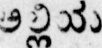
ಅಲ್ಲಿಯ
